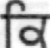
ਕਿ
